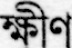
ক্ষীণ
